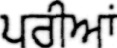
ਪਰੀਆਂ
